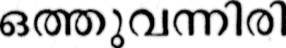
ഒത്തുവന്നിരി
